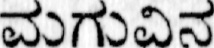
ಮಗುವಿನ
